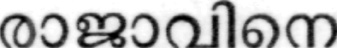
രാജാവിനെ
